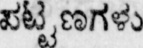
ಪಟ್ಟಣಗಳು
